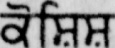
ਕੋਸ਼ਿਸ਼
